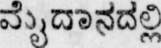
ಮೈದಾನದಲ್ಲಿ
